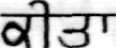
ਕੀਤਾ
